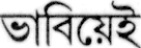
ভাবিয়েই
